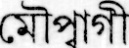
মৌপ্বাগী
